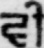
ਵੀ
